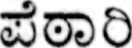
ಪೆಠಾರಿ
